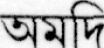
অমদি
